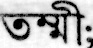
তম্মী;
